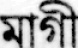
মাগী
